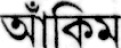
আঁকিম
